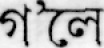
গ'লে
